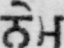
ਨੇਮ
